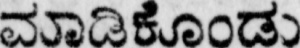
ಮಾಡಿಕೊಂಡು
